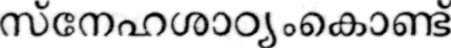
സ്നേഹശാഠ്യംകൊണ്ട്
